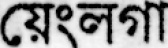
য়েংলগা
